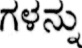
ಗಳನ್ನು
